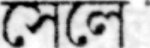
সেলে
